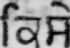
ਕਿਸੇ
